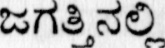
ಜಗತ್ತಿನಲ್ಲಿ
